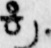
ಕ್ರಿ.
